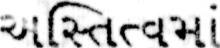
અસ્તિત્વમાં
